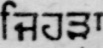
ਜਿਹੜਾ
